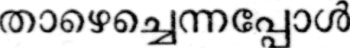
താഴെച്ചെന്നപ്പോള്‍
